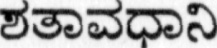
ಶತಾವಧಾನಿ
